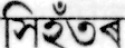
সিহঁতৰ
